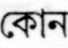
কোন
